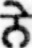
ਨੇ
